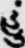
હું
